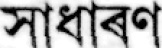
সাধাৰণ
